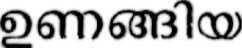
ഉണങ്ങിയ
